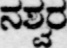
ನಶ್ವರ
